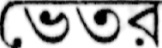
ভেতর
